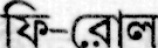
ফি-রোল
